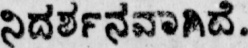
ನಿದರ್ಶನವಾಗಿದೆ.
